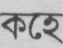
কহে
